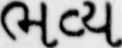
ભવ્ય
